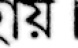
হায়
